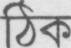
ঠিক
